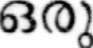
ഒരു
